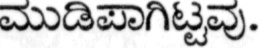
ಮುಡಿಪಾಗಿಟ್ಟವು.
